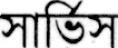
সার্ভিস
